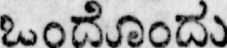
ಒಂದೊಂದು
